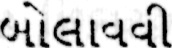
બોલાવવી
